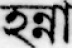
হন্না
